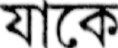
যাকে
